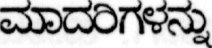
ಮಾದರಿಗಳನ್ನು
